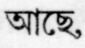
আছে,
